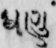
ઘણું
